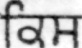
ਕਿਸ
